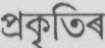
প্ৰকৃতিৰ
